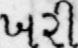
ખરી
